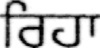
ਰਿਹਾ
